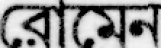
রোমেন
